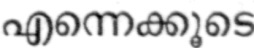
എന്നെക്കൂടെ
